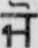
ਜੋ
